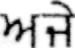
ਅਜੇ
